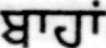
ਬਾਹਾਂ
